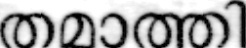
തമാത്തി
